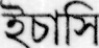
ইচাসি
